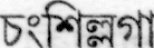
চংশিল্লগা
